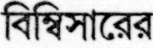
বিম্বিসারের
